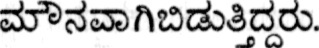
ಮೌನವಾಗಿಬಿಡುತ್ತಿದ್ದರು.
